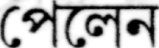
পেলেন
